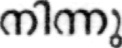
നിന്നു
